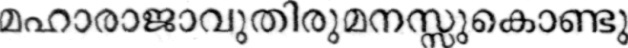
മഹാരാജാവുതിരുമനസ്സുകൊണ്ടു
